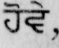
ਹੋਵੇ,
